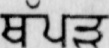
ਥੱਪੜ
